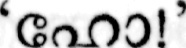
'ഹോ!'
